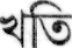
খতি
